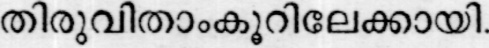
തിരുവിതാംകൂറിലേക്കായി.
